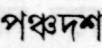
পঞ্চদশ
